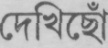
দেখিছোঁ
